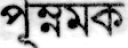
পূম্নমক
